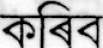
কৰিব
